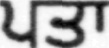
ਪਤਾ
